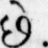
છે.
